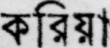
করিয়া
